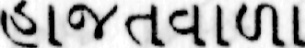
હાજતવાળા
